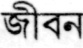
জীবন
